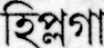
হিপ্লগা
